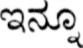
ಇನ್ನೂ
